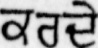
ਕਰਦੇ
